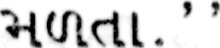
મળતા."
